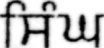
ਸਿੰਘ
